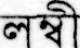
লম্বী
